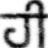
ਹੀ
